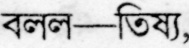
বলল–তিষ্য,
